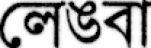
লেঙবা
